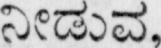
ನೀಡುವ,
